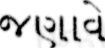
જણાવે
